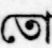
তো
